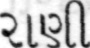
રાણી
